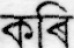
কৰি
